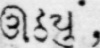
ઉઠ્યું,
